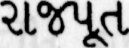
રાજપૂત
